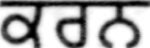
ਕਰਨ
